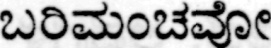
ಬರಿಮಂಚವೋ
